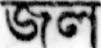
জল
